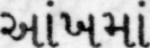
આંખમાં
